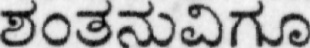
ಶಂತನುವಿಗೂ
